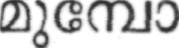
മുമ്പോ
